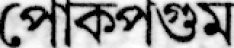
পোকপগুম
